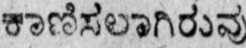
ಕಾಣಿಸಲಾಗಿರುವು
